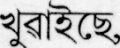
খুৱাইছে,
